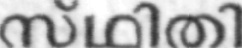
സ്ഥിതി
